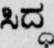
ಸಿದ್ಧ
